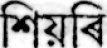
শিয়ৰি
